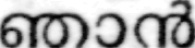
ഞാന്‍
